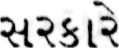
સરકારે
